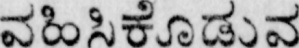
ವಹಿಸಿಕೊಡುವ
